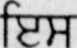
ਇਸ
